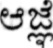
ಆಜ್ಞೆ
